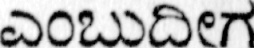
ಎಂಬುದೀಗ
